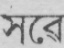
সৱে
